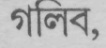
গলিব,
